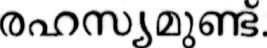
രഹസ്യമുണ്ട്.
